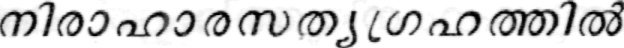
നിരാഹാരസത്യഗ്രഹത്തില്‍
